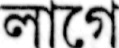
লাগে
